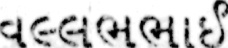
વલ્લભભાઈ
